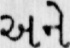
અને
